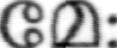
മേ:
